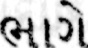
ભાગે
